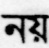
নয়
